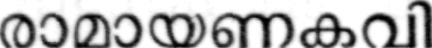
രാമായണകവി
